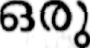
ഒരു
